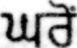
ਘਰੋਂ
